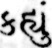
કહ્યું
